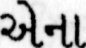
એના
